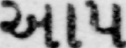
આપ
